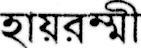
হায়রম্মী
